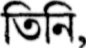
তিনি,
